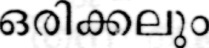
ഒരിക്കലും
